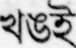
খঙই
